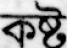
কষ্ট
